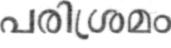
പരിശ്രമം
